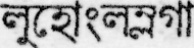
লুহোংলম্লগা
